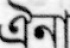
ঐনা
